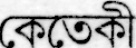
কেতেকী
